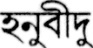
হনুবীদু
